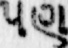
પણ
